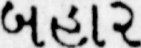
બહાર
